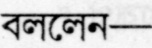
বললেন–
